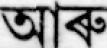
আৰু
